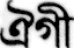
ঐগী
